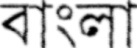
বাংলা
